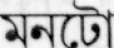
মনটো
